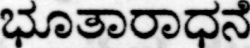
ಭೂತಾರಾಧನೆ
